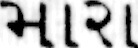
મારા
